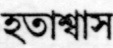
হতাশ্বাস
